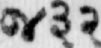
જરૂર
